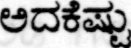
ಅದಕೆಷ್ಟು
